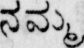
ನಮ್ಮ
